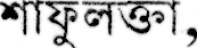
শাফুলক্তা,
